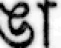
ঙা
